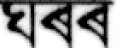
ঘৰৰ
